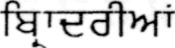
ਬ੍ਰਿਾਦਰੀਆਂ
